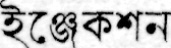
ইঞ্জেকশন
